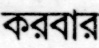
করবার
